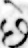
છે
